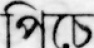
পিচে
